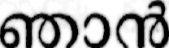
ഞാന്‍
